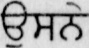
ਉਸਨੇ
